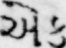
એક
